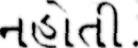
નહોતી.
